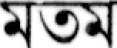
মতম
